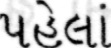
પહેલાં
